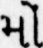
મોં
